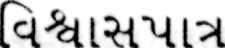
વિશ્વાસપાત્ર
